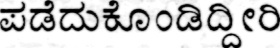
ಪಡೆದುಕೊಂಡಿದ್ದೀರಿ
